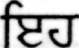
ਇਹ
